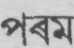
পৰম
